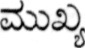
ಮುಖ್ಯ
